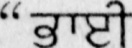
''ਭਾਈ
